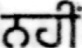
ਨਹੀਂ
